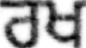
ਰਖ
